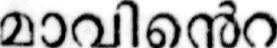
മാവിന്റെ
